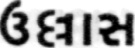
ઉલ્લાસ
